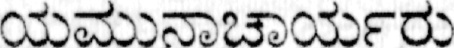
ಯಮುನಾಚಾರ್ಯರು
